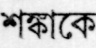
শঙ্কাকে
